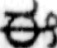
ಈ
